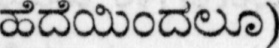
ಹೆದೆಯಿಂದಲೂ)
